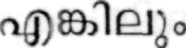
എങ്കിലും
